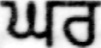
ਘਰ
